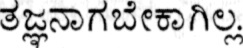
ತಜ್ಞನಾಗಬೇಕಾಗಿಲ್ಲ.
